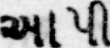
આપી
